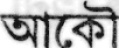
আকৌ
